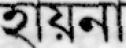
হায়না
